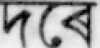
দৰে
